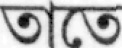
তাতে
